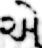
એ
